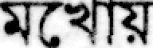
মখোয়
